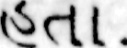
હતા.
